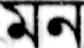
মন
